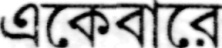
একেবারে
